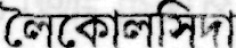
লৈকোলসিদা
